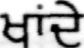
ਖਾਂਦੇ
